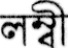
লম্বী
